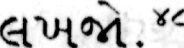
લખજો.૪૮
